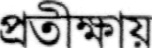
প্রতীক্ষায়
